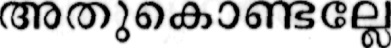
അതുകൊണ്ടല്ലേ
